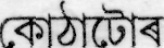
কোঠাটোৰ
